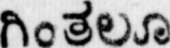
ಗಿಂತಲೂ
